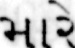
મારે
